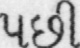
પછી
